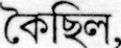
কৈছিল,
